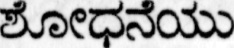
ಶೋಧನೆಯು
